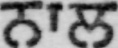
ਨਾਲ
